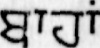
ਬਾਹਾਂ
